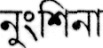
নুংশিনা
